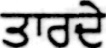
ਤਾਰਦੇ
